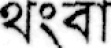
থংবা
